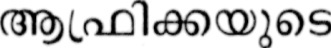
ആഫ്രിക്കയുടെ
